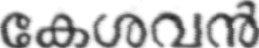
കേശവന്‍
